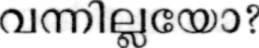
വന്നില്ലയോ?
